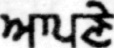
ਆਪਣੇ
